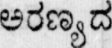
ಅರಣ್ಯದ
